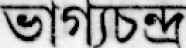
ভাগ্যচন্দ্র
